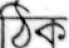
ঠিক
